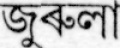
জুৰুলা
